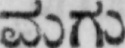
ಮಗು
